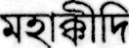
মহাক্কীদি
